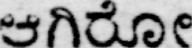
ಆಗಿರೋ
